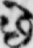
છે
